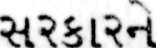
સરકારને
